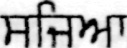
ਸਜਿਆ
